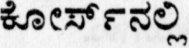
ಕೋರ್ಸ್‌ನಲ್ಲಿ
